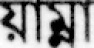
য়াম্না
